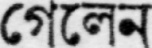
গেলেন
